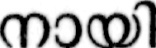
നായി
